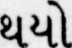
થયો
